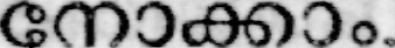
നോക്കാം.
